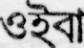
ওইবা
